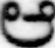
ಆ
